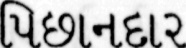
પિછાનદાર
